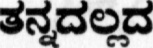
ತನ್ನದಲ್ಲದ
